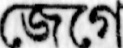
জেগে
